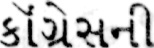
કૉંગ્રેસની
